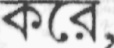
করে,
